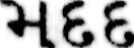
મદદ
